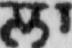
ਲਾ
